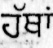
ਹੱਥਾਂ
